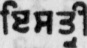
ਇਸਤ੍ਰੀ
